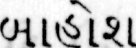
બાહોશ
